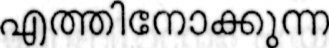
എത്തിനോക്കുന്ന
